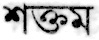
শক্তম
